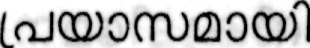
പ്രയാസമായി
